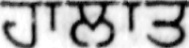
ਹਾਲਾਤ
